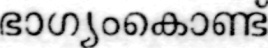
ഭാഗ്യംകൊണ്ട്
